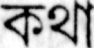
কথা
